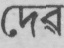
দেৱ
